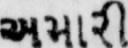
અમારી
